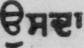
ਉਸਦਾ
